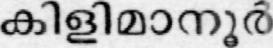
കിളിമാനൂര്‍
